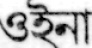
ওইনা
